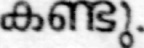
കണ്ടു.
